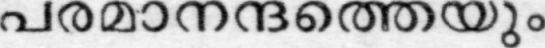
പരമാനന്ദത്തെയും
